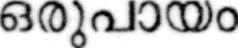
ഒരുപായം
